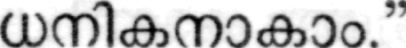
ധനികനാകാം.”
